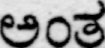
ಅಂತ
